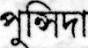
পুন্সিদা
